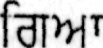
ਗਿਆ
